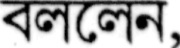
বললেন,
